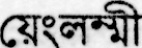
য়েংলম্মী
